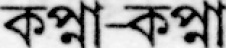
কপ্না-কপ্না
